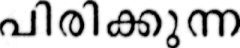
പിരിക്കുന്ന
